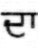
ਦਾ
